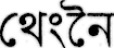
থেংনৈ
